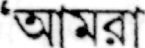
‘আমরা
